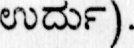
ಉರ್ದು).
